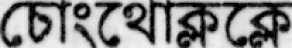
চোংথোক্লক্লে
